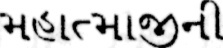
મહાત્માજીની
